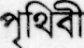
পৃথিবী
